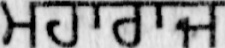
ਮਹਾਰਾਜ
